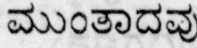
ಮುಂತಾದವು
